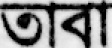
তাবা
